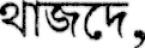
থাজদে,
